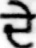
ਦੇ
